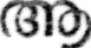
ആ
